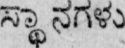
ಸ್ಥಾನಗಳು
